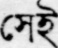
সেই
